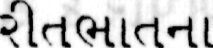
રીતભાતના
